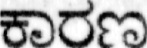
ಕಾರಣ
